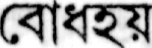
বোধহয়
